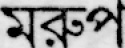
মরুপ
